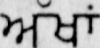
ਅੱਖਾਂ
